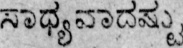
ಸಾಧ್ಯವಾದಷ್ಟು
